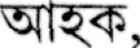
আহক,
